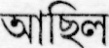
আছিল
